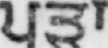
ਪੜਾ
